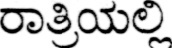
ರಾತ್ರಿಯಲ್ಲಿ
